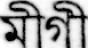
মীগী
